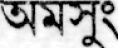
অমসুং
